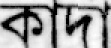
কাদা
